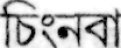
চিংনবা
